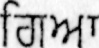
ਗਿਆ
